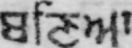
ਬਣਿਆ
